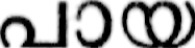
പായ
